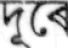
দূৰে
